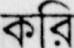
করি
